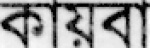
কায়বা
